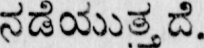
ನಡೆಯುತ್ತದೆ.
